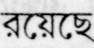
রয়েছে
